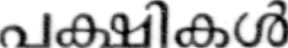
പക്ഷികള്‍
